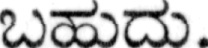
ಬಹುದು.
